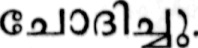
ചോദിച്ചു.
